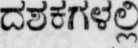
ದಶಕಗಳಲ್ಲಿ
